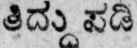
ತಿದ್ದುಪಡಿ
